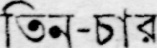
তিন-চার
